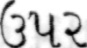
ઉપર
